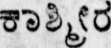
ಕಾಶ್ಮೀರ
